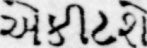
એકીટશે
